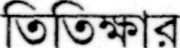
তিতিক্ষার
